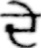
ਦੇ
